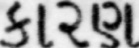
કારણ
